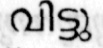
വിട്ടു
